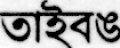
তাইবঙ
